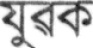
যুৱক
